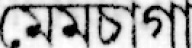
মেমচাগা
